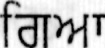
ਗਿਆ
